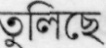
তুলিছে
